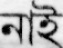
নাই
